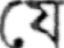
যে
